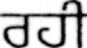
ਰਹੀ
